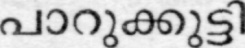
പാറുക്കുട്ടി
